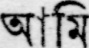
আমি
